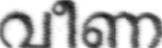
വീണ
